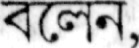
বলেন,
